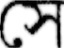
সে
